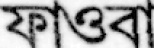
ফাওবা
